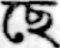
ছে
